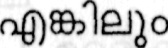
എങ്കിലും
